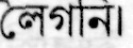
লৈগনি।
